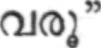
വരൂ”
